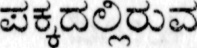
ಪಕ್ಕದಲ್ಲಿರುವ
